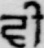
ਵੀ
